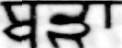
ਬੜਾ
